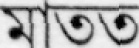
মাতত
